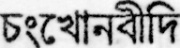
চংখোনবীদি
